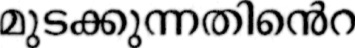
മുടക്കുന്നതിന്റെ
